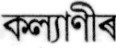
কল্যাণীৰ
